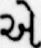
એ
